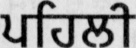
ਪਹਿਲੀ
